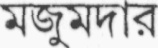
মজুমদার
